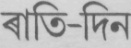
ৰাতি-দিন
